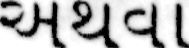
અથવા
